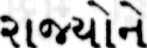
રાજ્યોને
